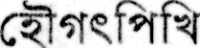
হৌগৎপিখি
